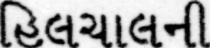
હિલચાલની
